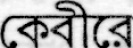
কেবীরে
